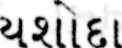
યશોદા
